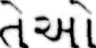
તેઓ
